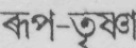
ৰূপ-তৃষ্ণা
